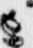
હું
